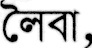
লৈবা,
